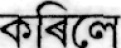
কৰিলে
